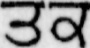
ਤਕ
